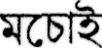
মচোই
